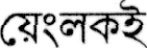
য়েংলকই
